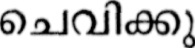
ചെവിക്കു
